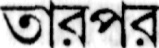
তারপর
